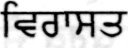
ਵਿਰਾਸਤ
